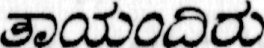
ತಾಯಂದಿರು
